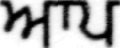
ਆਪ
